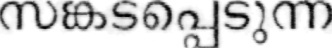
സങ്കടപ്പെടുന്ന
